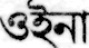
ওইনা
